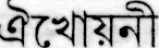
ঐখোয়নী
